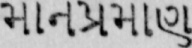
માનપ્રમાણ
